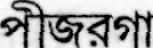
পীজরগা
